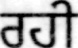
ਰਹੀ
